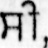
ਸੀ,
